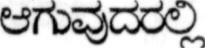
ಆಗುವುದರಲ್ಲಿ
